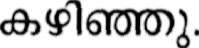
കഴിഞ്ഞു.
